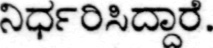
ನಿರ್ಧರಿಸಿದ್ದಾರೆ.
